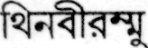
থিনবীরম্মু
